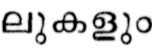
ലുകളും
